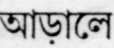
আড়ালে
